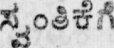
ಸ್ವಂತಿಕೆಗೆ
